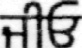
ਜੀਓ
